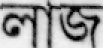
লাজ
